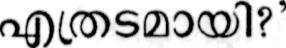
എത്രടമായി?'
